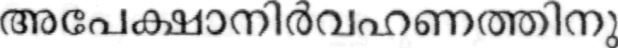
അപേക്ഷാനിര്‍വഹണത്തിനു
